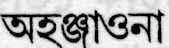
অহঞ্জাওনা
